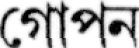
গোপন
